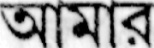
আমার
